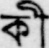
কী
